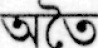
অতৈ
